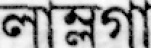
লাম্লগা
